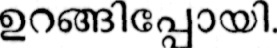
ഉറങ്ങിപ്പോയി.
